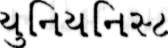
યુનિયનિસ્ટ
